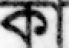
কা
